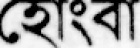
হোংবা
